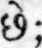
છે;
